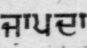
ਜਾਪਦਾ
